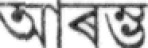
আৰম্ভ
